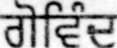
ਗੋਵਿੰਦ
